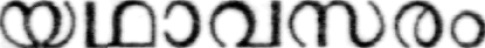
യഥാവസരം
